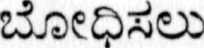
ಬೋಧಿಸಲು
